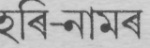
হৰি-নামৰ
